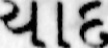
યાદ
